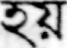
হয়
